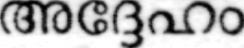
അദ്ദേഹം
